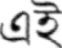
এই
